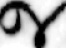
જ
